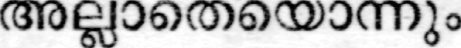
അല്ലാതെയൊന്നും
